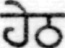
ਹੇਠ
